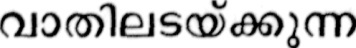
വാതിലടയ്ക്കുന്ന
